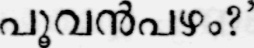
പൂവന്‍പഴം?'
